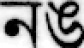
নঙ
